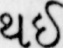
થઈ
